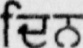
ਦਿਨ
